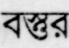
বস্তুর
